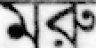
মরু
